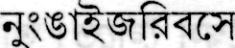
নুংঙাইজরিবসে
